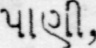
પાણી,
